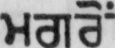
ਮਗਰੋਂ
